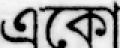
একো
